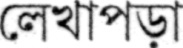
লেখাপড়া
